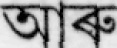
আৰু
